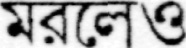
মরলেও
